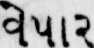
વેપાર
